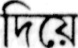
দিয়ে
